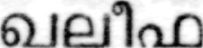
ഖലീഫ
